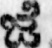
ಜೆ.
